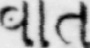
વાત
